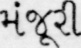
મંજૂરી
